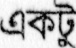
একটু
